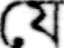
যে
